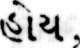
હોય,
